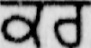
ਕਰ
